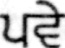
ਪਵੇ
